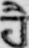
ਹੈ
